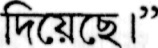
দিয়েছে।"
